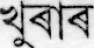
খুৰাৰ
